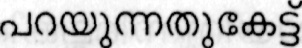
പറയുന്നതുകേട്ട്
